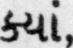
ક્યાં,
